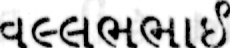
વલ્લભભાઈ
